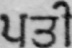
ਪਤੀ
